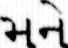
મને
